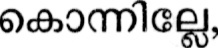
കൊന്നില്ലേ,
